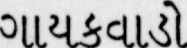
ગાયકવાડો
